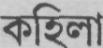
কহিলা
